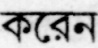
করেন
